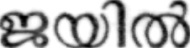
ജയില്‍
